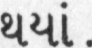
થયાં.
